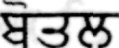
ਬੋਤਲ
